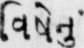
વિષેનું
